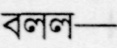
বলল–
